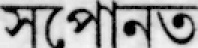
সপোনত
